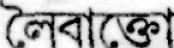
লৈবাক্তো
